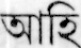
আহি
